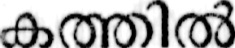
കത്തില്‍
